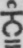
ਨੂੰ
